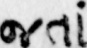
જતાં
